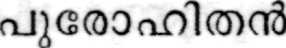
പുരോഹിതന്‍
